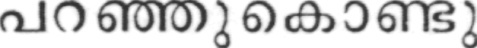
പറഞ്ഞുകൊണ്ടു
